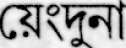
য়েংদুনা
